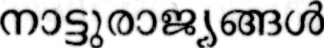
നാട്ടുരാജ്യങ്ങള്‍
